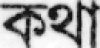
কথা
